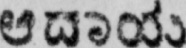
ಆದಾಯ
